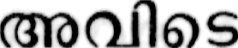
അവിടെ
